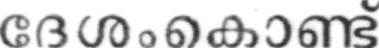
ദേശംകൊണ്ട്
